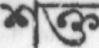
শক্ত
